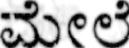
ಮೇಲೆ
